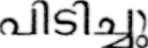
പിടിച്ചു
